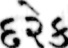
દરેક
